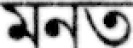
মনত
